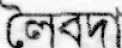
লৈবদা
